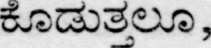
ಕೊಡುತ್ತಲೂ,
